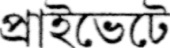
প্রাইভেটে
